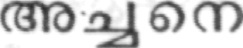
അച്ചനെ
